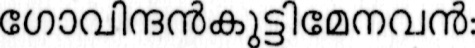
ഗോവിന്ദന്‍കുട്ടിമേനവന്‍:
